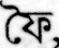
ফৈ,
